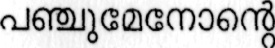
പഞ്ചുമേനോന്റെ
